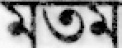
মতম
